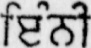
ਇੰਨੀ
